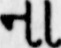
ના
